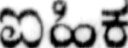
ಐಹಿಕ
